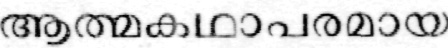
ആത്മകഥാപരമായ
